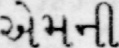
એમની
